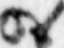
જ
